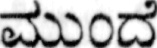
ಮುಂದೆ
